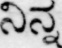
ನಿನ್ನ
